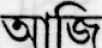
আজি
